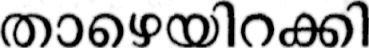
താഴെയിറക്കി
